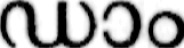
ഡാം
